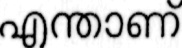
എന്താണ്
